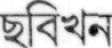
ছবিখন
